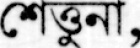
শেত্তুনা,
